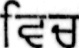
ਵਿਚ
